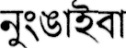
নুংঙাইবা
